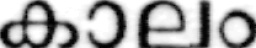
കാലം
